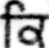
ਕਿ
